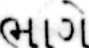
ભાગે
